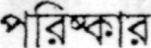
পরিষ্কার
